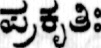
ಪ್ರಕೃತಿ:
